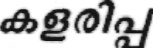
കളരിപ്പ
